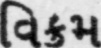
વિક્રમ
